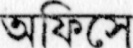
অফিসে
